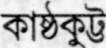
কাষ্ঠকুট্ট
